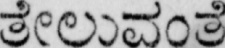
ತೇಲುವಂತೆ
